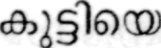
കുട്ടിയെ
